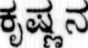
ಕೃಷ್ಣನ
